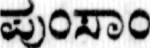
ಪುಂಸಾಂ
